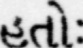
હતોઃ
